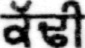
ਕੱਢੀ
